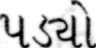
પડ્યો
